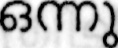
ഒന്നു
